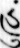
હું
